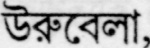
উরুবেলা,
